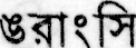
ঙরাংসি
